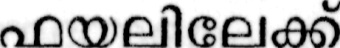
ഫയലിലേക്ക്
